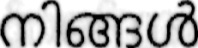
നിങ്ങള്‍
